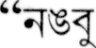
“নঙবু
